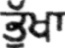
ਭੁੱਖਾ
